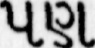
પણ
